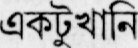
একটুখানি
